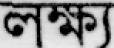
লক্ষ্য
